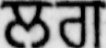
ਲਗ
